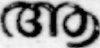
ആ
